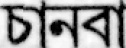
চানবা
